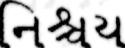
નિશ્ચય
